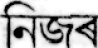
নিজৰ
